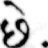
છે.
